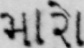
મારો
